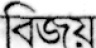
বিজয়
